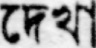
দেখা
